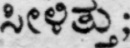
ಸೀಳಿತ್ತು;
